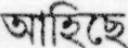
আহিছে
